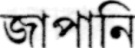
জাপানি
